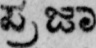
ಪ್ರಜಾ
